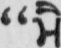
''ਮੈ
